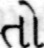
તો
